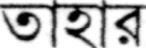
তাহার
